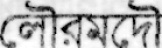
লৌরমদৌ
